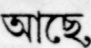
আছে,
